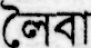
লৈবা
